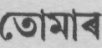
তোমাৰ
